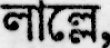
লাল্লে,
